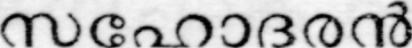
സഹോദരന്‍
